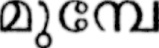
മുമ്പേ
